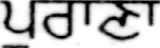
ਪੁਰਾਣਾ
